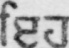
ਇਹ
